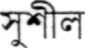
সুশীল
